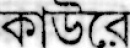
কাউরে
